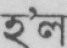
হ'ল
